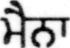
ਮੈਨਾ
